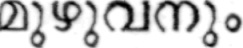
മുഴുവനും
